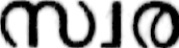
സ്വര
